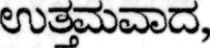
ಉತ್ತಮವಾದ,
